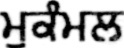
ਮੁਕੰਮਲ
